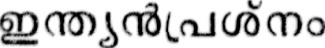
ഇന്ത്യന്‍പ്രശ്നം
